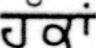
ਹੱਕਾਂ
